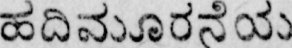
ಹದಿಮೂರನೆಯ
